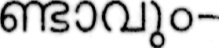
ണ്ടാവും-
